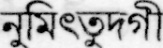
নুমিৎতুদগী
